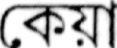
কেয়া
